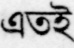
এতই
